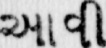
આવી
